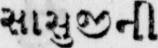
સાસુજીની
